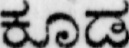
ಕೂಡ
